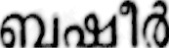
ബഷീര്‍
